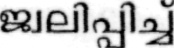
ജ്വലിപ്പിച്ച്
